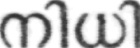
നിധി
